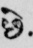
છે.
